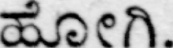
ಹೋಗಿ.
